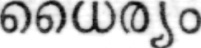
ധൈര്യം
